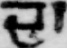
ਦਾ
